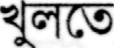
খুলতে
